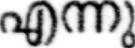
എന്നു
